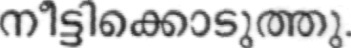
നീട്ടിക്കൊടുത്തു.
